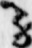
કે
